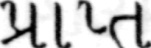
પ્રાપ્ત
